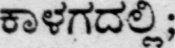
ಕಾಳಗದಲ್ಲಿ;
